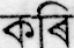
কৰি
